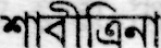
শাবীত্রিনা
